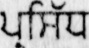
ਪ੍ਰਸਿੱਧ
